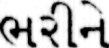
ભરીને
